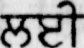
ਲਈ
